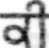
ਕੀ
